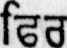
ਫਿਰ
